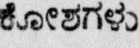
ಕೋಶಗಳು
